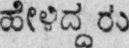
ಹೇಳಿದ್ದರು
